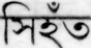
সিহঁত
